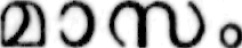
മാസം
